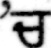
'ਚ
